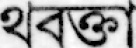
থবক্তা
